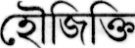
হৌজিক্তি
